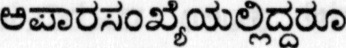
ಅಪಾರಸಂಖ್ಯೆಯಲ್ಲಿದ್ದರೂ
